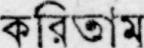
করিতাম
